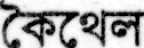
কৈথেল
